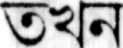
তখন
